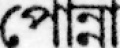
পোন্না
